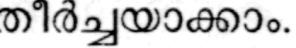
തീര്‍ച്ചയാക്കാം.
